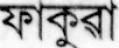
ফাকুৱা
